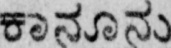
ಕಾನೂನು
